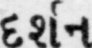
દર્શન
